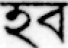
হব
